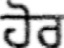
ਹੋਰ
